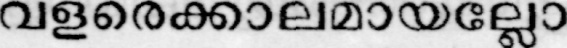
വളരെക്കാലമയല്ലോ
